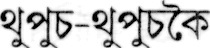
থুপুচ-থুপুচকৈ
